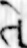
તે
